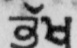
ਭੱਖ
